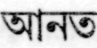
আনত
